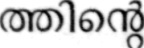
ത്തിന്റെ
